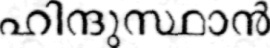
ഹിന്ദുസ്ഥാന്‍
